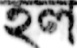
হল
